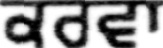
ਕਰਵਾ
